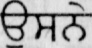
ਉਸਨੇ
